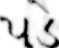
પડે
